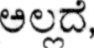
ಅಲ್ಲದೆ,
